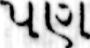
પણ
